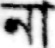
না
